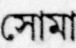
সোমা
